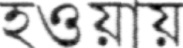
হওয়ায়
